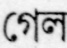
গেল
